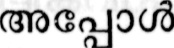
അപ്പോള്‍
